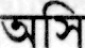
অসি
